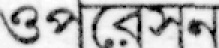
ওপরেসন
